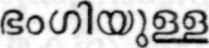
ഭംഗിയുള്ള
